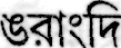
ঙরাংদি
